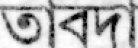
তাবদা
